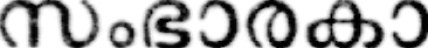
സംഭാരകാ
